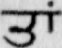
ਤਾਂ
